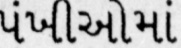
પંખીઓમાં
